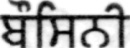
ਬੌਸਿਨੀ
